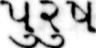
પુરુષ
